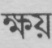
ক্ষয়
